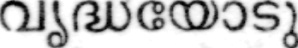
വൃദ്ധയോടു
